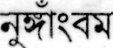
নুঙ্গাংবম
